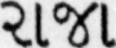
રાજા
